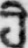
ਹੈ
